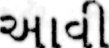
આવી
